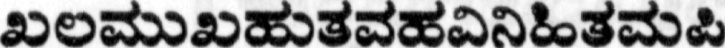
ಖಲಮುಖಹುತವಹವಿನಿಹಿತಮಪಿ
